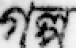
গল্প
